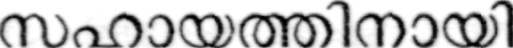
സഹായത്തിനായി
